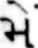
મેં
